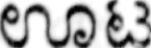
ಊಟ
